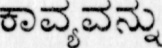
ಕಾವ್ಯವನ್ನು
